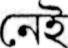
নেই
